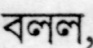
বলল,
